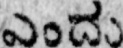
ಎಂದು
